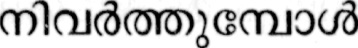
നിവര്‍ത്തുമ്പോള്‍
